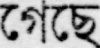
গেছে
